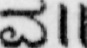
ವ||
